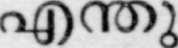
എന്തു
